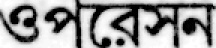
ওপরেসন
